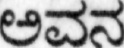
ಅವನ
